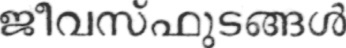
ജീവസ്ഫുടങ്ങള്‍
